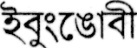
ইবুংঙোবী
